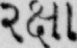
રક્ષા
